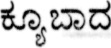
ಕ್ಯೂಬಾದ
